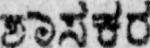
ಶಾಸಕರ
